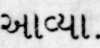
આવ્યા.
